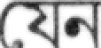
যেন
